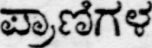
ಪ್ರಾಣಿಗಳ
